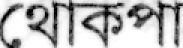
থোকপা
